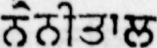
ਨੈਨੀਤਾਲ
